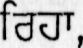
ਰਿਹਾ,
